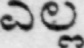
ಎಲ್ಲ
